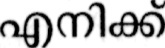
എനിക്ക്
